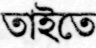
তাইতে
